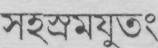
সহস্ৰমযুতং
